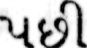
પછી
